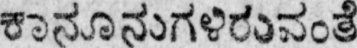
ಕಾನೂನುಗಳಿರುವಂತೆ
